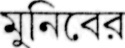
মুনিবের
